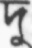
দু
